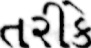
તરીકે
